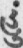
હું
